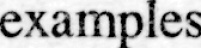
examples
